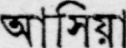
আসিয়া
